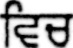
ਵਿਚ
